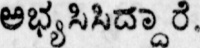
ಅಭ್ಯಸಿಸಿದ್ದಾರೆ.
